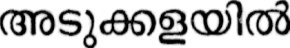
അടുക്കളയില്‍
